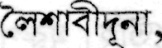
লৈশাবীদূনা,
